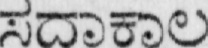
ಸದಾಕಾಲ
